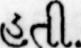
હતી.
